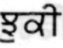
ਝੁਕੀ
